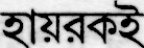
হায়রকই
